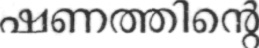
ഷണത്തിന്റെ
